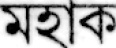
মহাক
